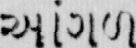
આંગળ
